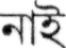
নাই
